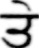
ਤੇ
